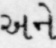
અને
